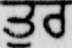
ਤੁਰ
